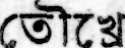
তৌখ্রে
